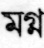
মগ্ন
